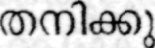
തനിക്കു
